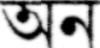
অন
